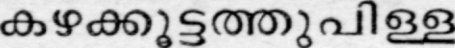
കഴക്കൂട്ടത്തുപിള്ള
